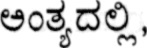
ಅಂತ್ಯದಲ್ಲಿ,
